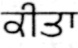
ਕੀਤਾ
